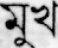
মুখ
